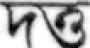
দত্ত
